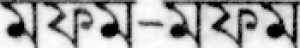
মফম-মফম
